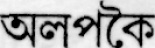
অলপকৈ
